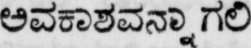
ಅವಕಾಶವನ್ನಾಗಲಿ
